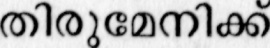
തിരുമേനിക്ക്
